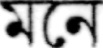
মনে
